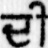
ਦੀ
